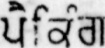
ਪੈਕਿੰਗ
